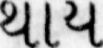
થાય
